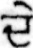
ਦੇ
